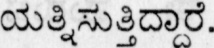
ಯತ್ನಿಸುತ್ತಿದ್ದಾರೆ.
